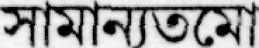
সামান্যতমো
